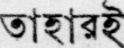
তাহারই
